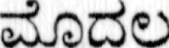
ಮೊದಲ
